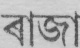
ৰাজা
